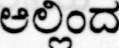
ಅಲ್ಲಿಂದ
